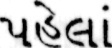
પહેલાં
